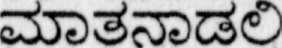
ಮಾತನಾಡಲಿ
